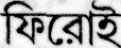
ফিরোই
